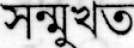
সন্মুখত
